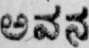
ಅವನ
